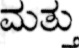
ಮತ್ತು
